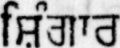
ਸ਼ਿੰਗਾਰ
